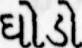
ઘોડો
